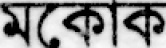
মকোক
